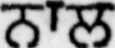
ਨਾਲ
